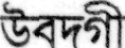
উবদগী
